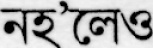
নহ'লেও
